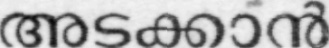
അടക്കാന്‍
